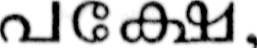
പക്ഷേ,
